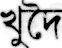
খুদৈ
